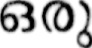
ഒരു
